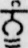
ਨੂੰ
